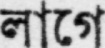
লাগে
